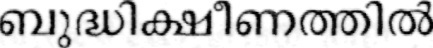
ബുദ്ധിക്ഷീണത്തില്‍
